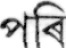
পৰি
